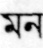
মন
